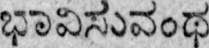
ಭಾವಿಸುವಂಥ
